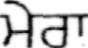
ਮੇਰਾ
